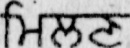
ਮਿਲਣ
